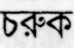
চরুক
